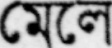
মেলে
